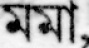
মমা,
